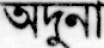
অদুনা
